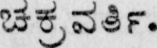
ಚಕ್ರವರ್ತಿ.
